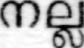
നല്ല
